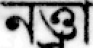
নত্ত্রা
